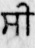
ਸੀ
